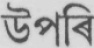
উপৰি
